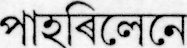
পাহৰিলেনে
